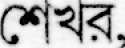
শেখর
